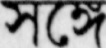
সঙ্গে
